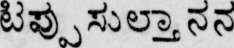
ಟಿಪ್ಪುಸುಲ್ತಾನನ
